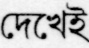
দেখেই
